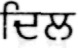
ਦਿਲ
